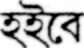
হইবে
